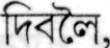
দিবলৈ,
